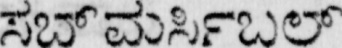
ಸಬ್ಮರ್ಸಿಬಲ್
